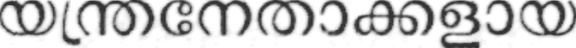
യന്ത്രനേതാക്കളായ
